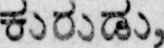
ಕುರುಡು,
